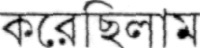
করেছিলাম
